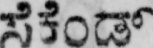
ಸೆಕೆಂಡ್
